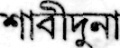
শাবীদুনা
